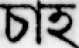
চাহ
